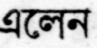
এলেন
